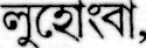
লুহোংবা,
